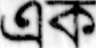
এক
